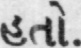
હતો.
